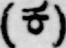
(ಕ)
